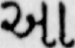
આ
